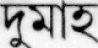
দুমাহ
